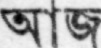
আজ
